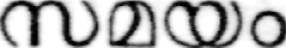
സമയം
